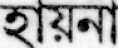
হায়না
